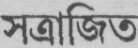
সত্ৰাজিত
